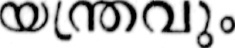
യന്ത്രവും
